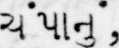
ચંપાનું,
